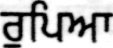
ਰੁਪਿਆ
